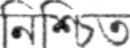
নিশ্চিত
